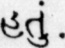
હતું.
